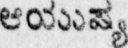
ಆಯುಷ್ಯ
